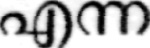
എന്ന
